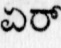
ಏರ್
